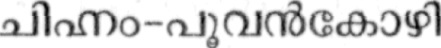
ചിഹ്നം-പൂവന്‍കോഴി
